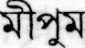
মীপুম
